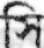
সি
